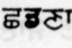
ਛਡਣਾ
